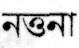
নত্তনা
